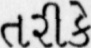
તરીકે
